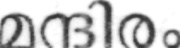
മന്ദിരം
